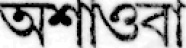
অশাওবা
